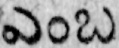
ಎಂಬ
